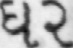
ઘર
